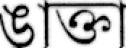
ঙাক্তা
